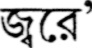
জ্বরে’
